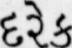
દરેક
